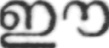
ഈ
